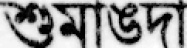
শুমাঙাদ
